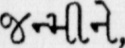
જન્મીને,
